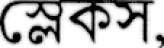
স্লেকস,
